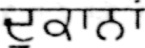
ਦੁਕਾਨਾ
